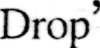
Drop’
